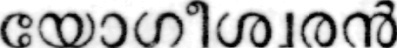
യോഗീശ്വരന്‍
